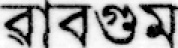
ৱাবগুম
